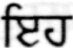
ਇਹ
